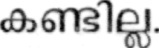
കണ്ടില്ല.
